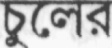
চুলের
